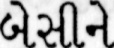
બેસીને
